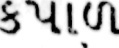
કપાળ
